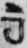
ਹੈ
